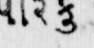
પારકું
